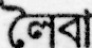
লৈবা
